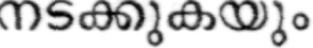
നടക്കുകയും
